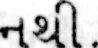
નથી.
